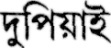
দুপিয়াই
